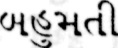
બહુમતી
